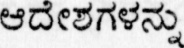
ಆದೇಶಗಳನ್ನು
